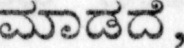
ಮಾಡದೆ,
